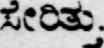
ಸೇರಿತ್ತು.
